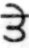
ਤੇ
